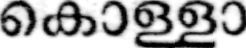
കൊള്ളാ
